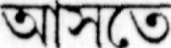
আসতে
